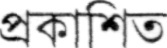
প্রকাশিত
